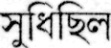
সুধিছিল
